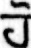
ਹੋ
